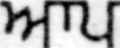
ਆਪ
